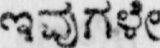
ಇವುಗಳೇ
